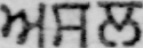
ਅਸਲ
